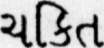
ચકિત
